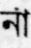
না
